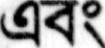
এবং
